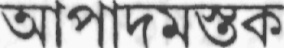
আপাদমস্তক
